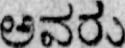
ಅವರು
